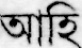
আহি
